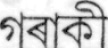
গৰাকী
